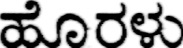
ಹೊರಳು
